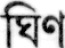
ঘিণ
